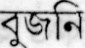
বুজনি
